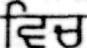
ਵਿਚ
